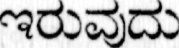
ಇರುವುದು
